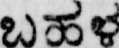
ಬಹಳ
